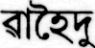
ৱাহৈদু
